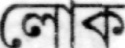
লোক
